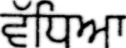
ਵੱਧਿਆ
